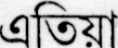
এতিয়া
